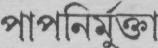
পাপনিৰ্মুক্তা
